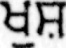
ਖੁਸ਼
